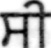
ਸੀ
